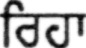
ਰਿਹਾ
